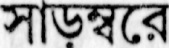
সাড়ম্বরে
